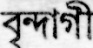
বৃন্দাগী
